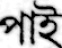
পাই
